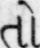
તો
